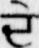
ਦੇ
